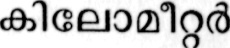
കിലോമീറ്റര്‍
